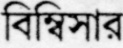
বিম্বিসার
